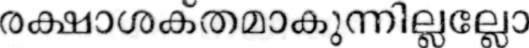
രക്ഷാശക്തമാകുന്നില്ലല്ലോ
